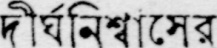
দীর্ঘনিশ্বাসের
